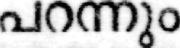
പറന്നും
